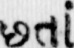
છતાં
